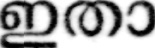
ഇതാ
